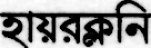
হায়রক্লনি
